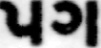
પગ
